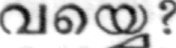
വയ്യെ?
